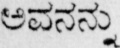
ಅವನನ್ನು
